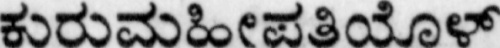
ಕುರುಮಹೀಪತಿಯೊಳ್
